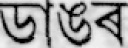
ডাঙৰ
